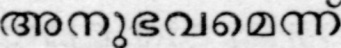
അനുഭവമെന്ന്
